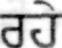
ਰਹੇ
